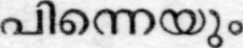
പിന്നെയും
